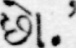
છો.'
